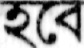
হবে
